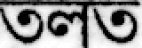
তলত
